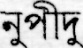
নুপীদু
